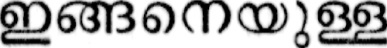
ഇങ്ങനെയുള്ള
